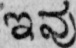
ಇವು
